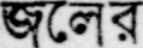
জলের
